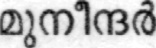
മുനീന്ദര്‍
